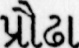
પ્રૌઢા
